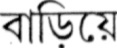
বাড়িয়ে
